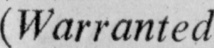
(Warranted
